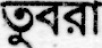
তুবরা
